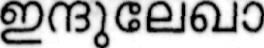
ഇന്ദുലേഖാ
